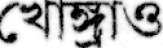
খোঙ্গ্রাও
